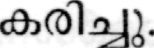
കരിച്ചു.
